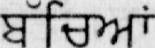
ਬੱਚਿਆਂ
